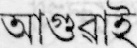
আগুৱাই
